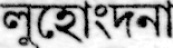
লুংহোদনা
